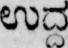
ಉದ್ದ
